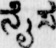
ನೈಸ
